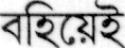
বহিয়েই
